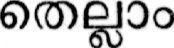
തെല്ലാം
